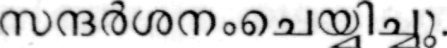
സന്ദര്‍ശനംചെയ്യിച്ചു.
